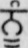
ਨੂੰ
